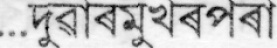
...দুৱাৰমুখৰপৰা
